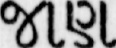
જાણ
